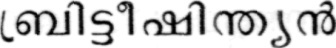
ബ്രിട്ടീഷിന്ത്യന്‍
